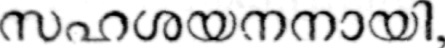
സഹശയനനായി,
